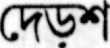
দেড়শ
